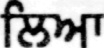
ਲਿਆ
